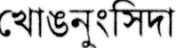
খোঙনুংসিদা
